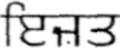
ਇਜ਼ਤ
